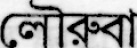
লৌরুবা
